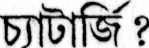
চ্যাটার্জি?
